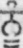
ਨੂੰ
